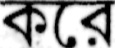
করে
